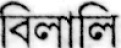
বিলালি
